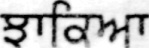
ਝਾਕਿਆ
